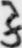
કે
